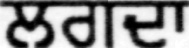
ਲਗਦਾ
